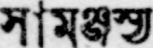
সামঞ্জস্য
